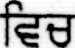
ਵਿਚ
